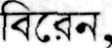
বিরেন,
